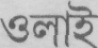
ওলাই
